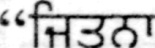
''ਜਿਤਨਾ
